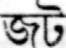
জট
